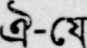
ঐ-যে
